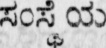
ಸಂಸ್ಥೆಯ
